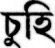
চুহি
